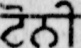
ਟੋਨੀ
